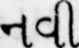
નવી
